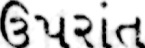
ઉપરાંત
